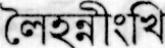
লৈহন্নীংখি
